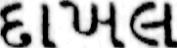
દાખલ
